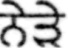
ਨੇੜੇ
